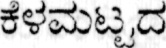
ಕೆಳಮಟ್ಟದ
